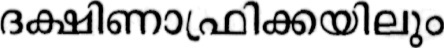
ദക്ഷിണാഫ്രിക്കയിലും
